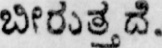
ಬೀರುತ್ತದೆ.
